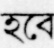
হবে
